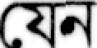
যেন
